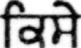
ਕਿਸੇ
